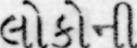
લોકોની
